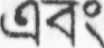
এবং
